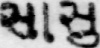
સાસુ
